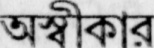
অস্বীকার
